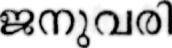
ജനുവരി
